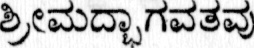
ಶ್ರೀಮದ್ಭಾಗವತವು
